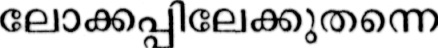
ലോക്കപ്പിലേക്കുതന്നെ
